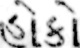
હોકો
